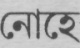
নোহে
